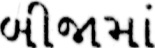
બીજામાં
